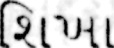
શિખા
